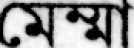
মেম্মা
